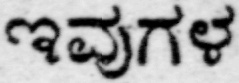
ಇವುಗಳ
